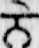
ਨੇ
